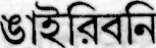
ঙাইরিবনি
